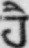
ਹੈ
